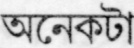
অনেকটা
